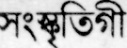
সংস্কৃতিগী
